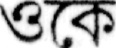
ওকে
